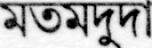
মতমদুদা
